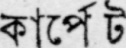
কার্পেট
